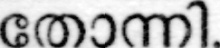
തോന്നി.
